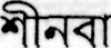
শীনবা
